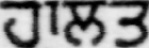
ਹਾਲਤ
